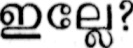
ഇല്ലേ?
